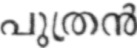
പുത്രന്‍
